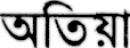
অতিয়া
